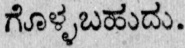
ಗೊಳ್ಳಬಹುದು.
